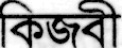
কিজবী
